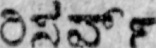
ರಿಸರ್ವ್
